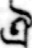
ঐ
